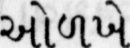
ઓળખે
